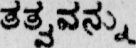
ತತ್ವವನ್ನು
